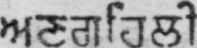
ਅਣਗਹਿਲੀ
